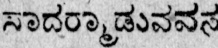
ಸಾದರ್‍ಮಾಡುವವನ
